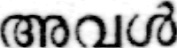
അവള്‍
